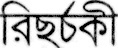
রিছর্চকী
